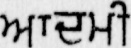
ਆਦਮੀ
